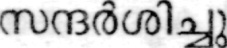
സന്ദര്‍ശിച്ചു
